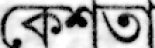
কেশতা
